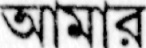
আমার
